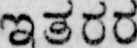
ಇತರರ
